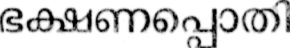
ഭക്ഷണപ്പൊതി
